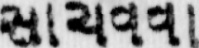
સાચવવા
